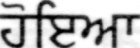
ਹੋਇਆ
